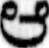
ಆ
